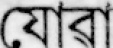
যোৱা
